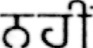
ਨਹੀਂ
